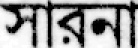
সারনা
